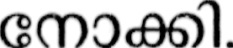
നോക്കി.
